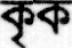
কৃক
